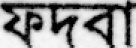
ফদবা
